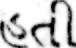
હતી
